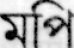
মপি
